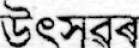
উৎসৱৰ
